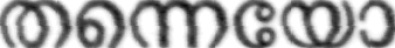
തന്നെയോ
